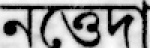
নত্তেদা
